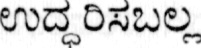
ಉದ್ಧರಿಸಬಲ್ಲ
